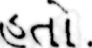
હતો.
